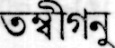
তম্বীগনু
